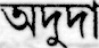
অদুদা
